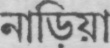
নাড়িয়া
